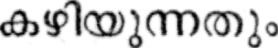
കഴിയുന്നതും
